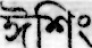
ঈশিং
